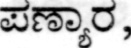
ಪಣ್ಯಾರ,
